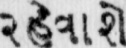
રહેવાશે
